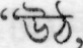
"উঠ,
